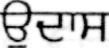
ਉਦਾਸ
